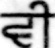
ਵੀ
